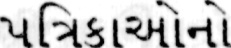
પત્રિકાઓનો
